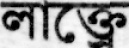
লাক্ত্রে
